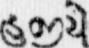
હજીયે
